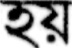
হয়
